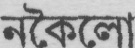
নকৈলো
